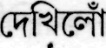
দেখিলোঁ
